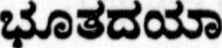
ಭೂತದಯಾ
